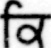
ਕਿ
